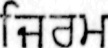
ਜਿਰਮ
